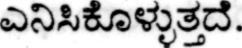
ಎನಿಸಿಕೊಳ್ಳುತ್ತದೆ.
